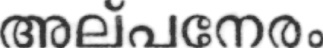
അല്പനേരം
